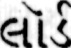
લૉર્ડ
